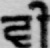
ਵੀ
